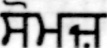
ਸੋਮਜ਼
